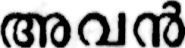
അവന്‍
